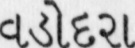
વડોદરા
